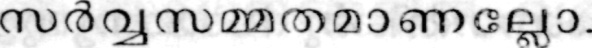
സര്‍വ്വസമ്മതമാണല്ലോ.
